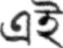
এই
